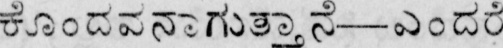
ಕೊಂದವನಾಗುತ್ತಾನೆ-ಎಂದರೆ
